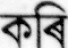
কৰি
